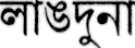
লাঙদুনা
